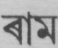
ৰাম
